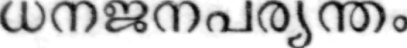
ധനജനപര്യന്തം
